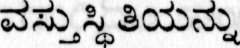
ವಸ್ತುಸ್ಥಿತಿಯನ್ನು
